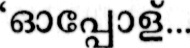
‘ഓപ്പോള്...
